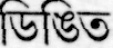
ডিঙিত
